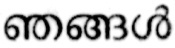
ഞങ്ങള്‍
